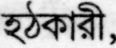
হঠকারী,
